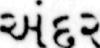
અંદર
